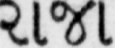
રાજા
